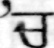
'ਚ
